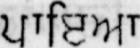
ਪਾਇਆ
